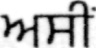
ਅਸੀਂ
